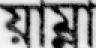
য়াম্না
